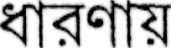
ধারণায়
